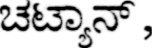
ಚಟ್ಯಾನ್,
